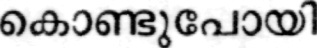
കൊണ്ടുപോയി.
